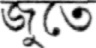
জুতে
